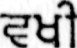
ਵਖੀ
